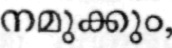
നമുക്കും,
